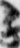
કે
